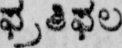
ಫ್ರತಿಫಲ
